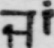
ਜਾਂ
